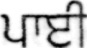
ਪਾਈ
